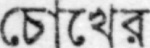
চোখের
